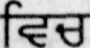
ਵਿਚ
